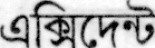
এক্সিদেন্ট
